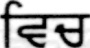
ਵਿਚ
